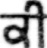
ਕੀ
